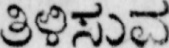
ತಿಳಿಸುವ
